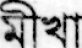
মীখা
